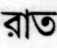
রাত
